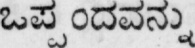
ಒಪ್ಪಂದವನ್ನು
